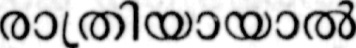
രാത്രിയായാല്‍
